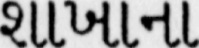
શાખાના
